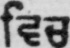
ਵਿਚ
